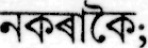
নকৰাকৈ;
